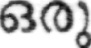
ഒരു
